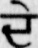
ਦੇ
